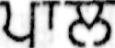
ਪਾਲ
